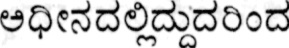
ಅಧೀನದಲ್ಲಿದ್ದುದರಿಂದ
